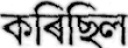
কৰিছিল
